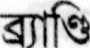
ব্র্যাণ্ডি
